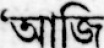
'আজি
